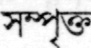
সম্পৃক্ত
